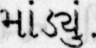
માંડ્યું.
